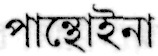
পান্থোইনা
